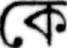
কে
